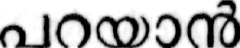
പറയാന്‍
